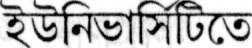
ইউনিভার্সিটিতে
